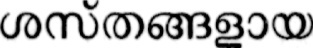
ശസ്തങ്ങളായ
